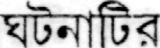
ঘটনাটির
